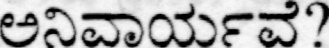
ಅನಿವಾರ್ಯವೆ?
